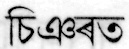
চিঞৰত
